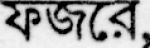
ফজরে,
